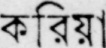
করিয়া
